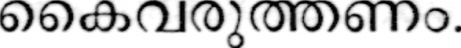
കൈവരുത്തണം.
